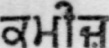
ਕਮੀਜ਼
